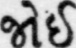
જોઈ
